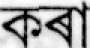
কৰা
